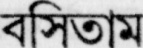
বসিতাম
